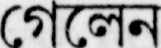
গেলেন
